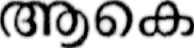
ആകെ
